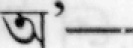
অ'-
